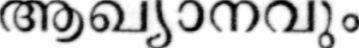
ആഖ്യാനവും
